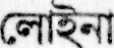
লোইনা
